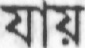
যায়
